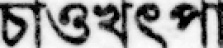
চাওখৎপা
